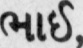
ભાઈ,
